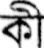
কী
